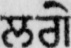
ਲਗੇ
